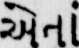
એનાં
